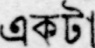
একটা
